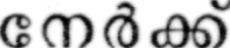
നേര്‍ക്ക്
